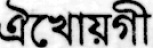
ঐখোয়গী
